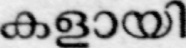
കളായി
